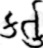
કર્તુ
